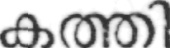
കത്തി
